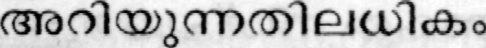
അറിയുന്നതിലധികം
